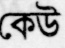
কেউ
